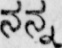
ನನ್ನ
